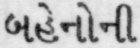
બહેનોની
